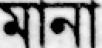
মানা
